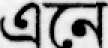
এনে
